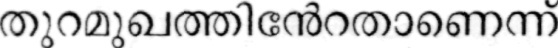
തുറമുഖത്തിന്റേതാണെന്ന്
